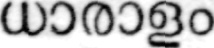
ധാരാളം
